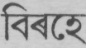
বিৰহে
